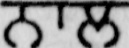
ਨਾਲ
